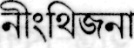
নীংথিজনা
